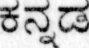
ಕನ್ನಡ
